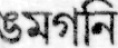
ঙমগনি
